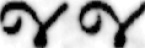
જજ
